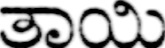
ತಾಯಿ
